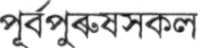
পূর্বপুৰুষসকল
